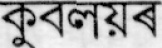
কুবলয়ৰ
